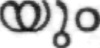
യും
